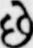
છે
